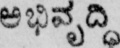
ಅಭಿವೃದ್ಧಿ
